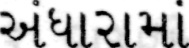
અંધારામાં
